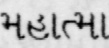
મહાત્મા
